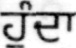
ਹੁੰਦਾ
